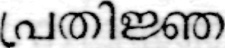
പ്രതിജ്ഞ
